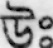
উঃ
